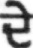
ਦੇ
